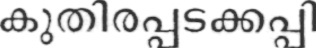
കുതിരപ്പടക്കപ്പി
